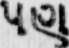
પણ
